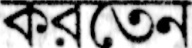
করতেন
